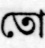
তো
